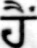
ਹੈਂ
